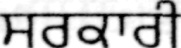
ਸਰਕਾਰੀ
